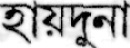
হায়দুনা
